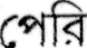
পেরি
